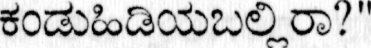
ಕಂಡುಹಿಡಿಯಬಲ್ಲಿರಾ?”
